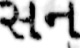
સન
